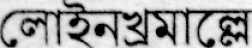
লোইনখ্রমাল্লে
